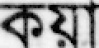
কয়া
